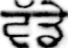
ਵੱਡੇ
